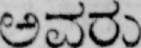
ಅವರು
